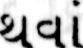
થવાં
